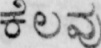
ಕೆಲವು
